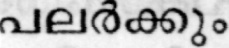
പലര്‍ക്കും
